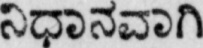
ನಿಧಾನವಾಗಿ
